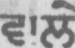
ਵਾਲੇ
